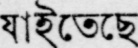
যাইতেছে
